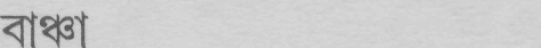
বাঞ্চা
